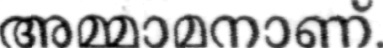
അമ്മാമനാണ്.
